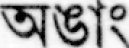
অঙাং
